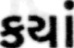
ક્યાં
